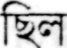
ছিল
